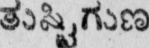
ತುಷ್ಟಿಗುಣ
